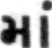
માં
